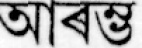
আৰম্ভ
